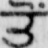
ਤੋਂ
